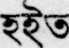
হইত
